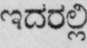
ಇದರಲ್ಲಿ
